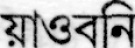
য়াওবনি
